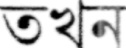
তখন
